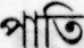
পাতি
